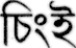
চিংই
